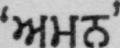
'ਅਮਨ'
